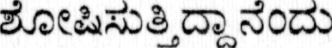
ಶೋಷಿಸುತ್ತಿದ್ದಾನೆಂದು
